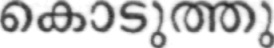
കൊടുത്തു
